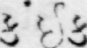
કંઈક
